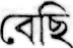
বেছি
